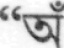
"অঁ
